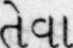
તેવા
